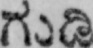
ಗುಡಿ
